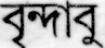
বৃন্দাবু
